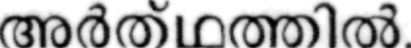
അര്‍ത്ഥത്തില്‍.
